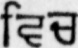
ਵਿਚ
